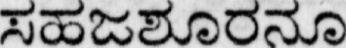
ಸಹಜಶೂರನೂ
